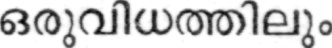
ഒരുവിധത്തിലും
